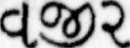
વજીર
